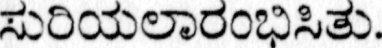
ಸುರಿಯಲಾರಂಭಿಸಿತು.
